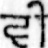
ਵੀ
